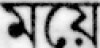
ময়ে
